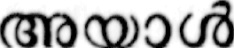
അയാള്‍
